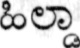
ಹಿಲ್ಡಾ
